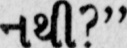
નથી?"
